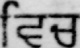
ਵਿਚ
